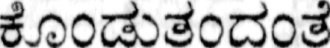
ಕೊಂಡುತಂದಂತೆ
